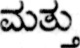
ಮತ್ತು
